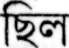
ছিল
